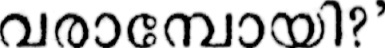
വരാമ്പോയി?’
